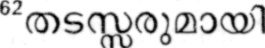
62തടസ്സരുമായി
